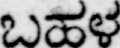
ಬಹಳ
